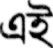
এই
